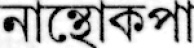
নান্থোকপা
